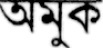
অমুক
